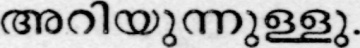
അറിയുന്നുള്ളു.
